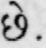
છે.
